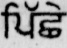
ਪਿੱਛੇ
